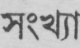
সংখ্যা
